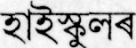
হাইস্কুলৰ
